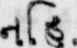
નહિ.
